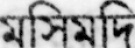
মসিমদি
